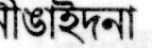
নীঙাইদনা
